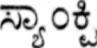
ಸ್ಯಾಂಕ್ಟಿ
